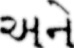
અને
